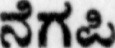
ನೆಗಪಿ
